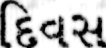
દિવસ
